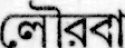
লৌরবা
